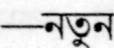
–নতুন
